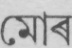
মোৰ
